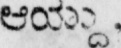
ಆಯ್ದು,
